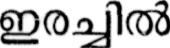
ഇരച്ചില്‍
